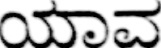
ಯಾವ
